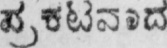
ಪ್ರಕಟವಾದ
